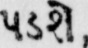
પડશે,
